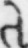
તે
